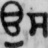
ਉਸ
